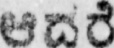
ಆದರೆ
